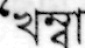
‘খম্বা
